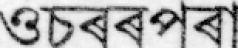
ওচৰৰপৰা
